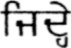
ਜਿਦ੍ਹੇ
